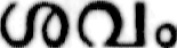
ശവം
